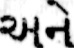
અને
